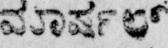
ಮಾರ್ಷಲ್
